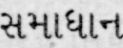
સમાધાન
